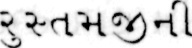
રુસ્તમજીની
